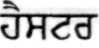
ਹੈਸਟਰ
